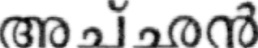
അച്ഛന്‍
